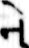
ને
